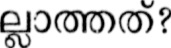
ല്ലാത്തത്?
